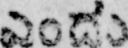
ಎಂದು
